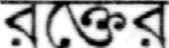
রক্তের
